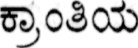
ಕ್ರಾಂತಿಯ
